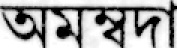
অমম্বদা
